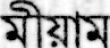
মীয়াম
